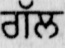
ਗੱਲ
